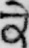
ਕੇ
